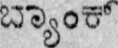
ಬ್ಯಾಂಕ್
